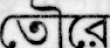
তৌরে
